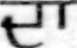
ਦਾ
